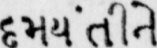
દમયંતીને
